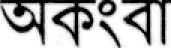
অকংবা
